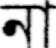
না
